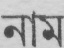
নাম
